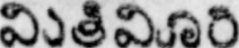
ಮಿತಿಮೀರಿ
